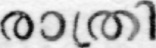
രാത്രി
